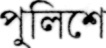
পুলিশে
